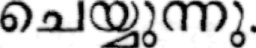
ചെയ്യുന്നു.
